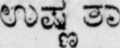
ಉಷ್ಣತಾ
